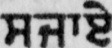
ਸਜਾਏ
